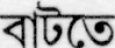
বাটতে
